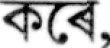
কৰে,
